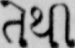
તેથી
